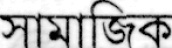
সামাজিক
